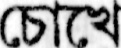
চোখে
